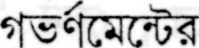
গভর্ণমেন্টের
